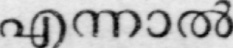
എന്നാല്‍
